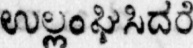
ಉಲ್ಲಂಘಿಸಿದರೆ
